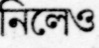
নিলেও
